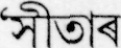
'সীতাৰ
